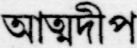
আত্মদীপ
